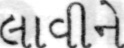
લાવીને
